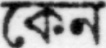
কেন
